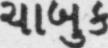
ચાબુક
